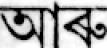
আৰু
